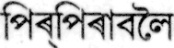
পিৰ্‌পিৰাবলৈ
